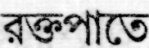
রক্তপাতে
